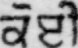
ਕੋਈ
